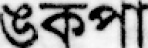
ঙকপা
